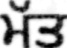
ਮੱਤ
